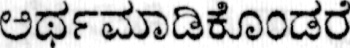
ಅರ್ಥಮಾಡಿಕೊಂಡರೆ
